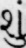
શું
